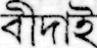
বীদাই
